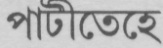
পাটীতেহে
